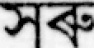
সৰু
